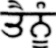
ਤੈਨੂੰ
